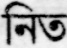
নিত
